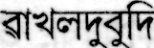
ৱাখলদুবুদি
